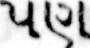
પણ
